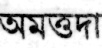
অমত্তদা
